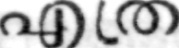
എത്ര
